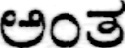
ಅಂತ
